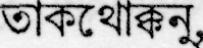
তাকথোক্কনু,
